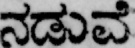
ನಡುವೆ
